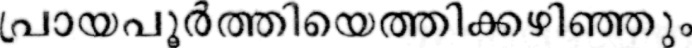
പ്രായപൂര്‍ത്തിയെത്തിക്കഴിഞ്ഞും
